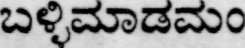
ಬಳ್ಳಿಮಾಡಮಂ
